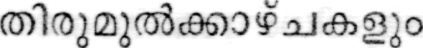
തിരുമുല്‍ക്കാഴ്ചകളും
